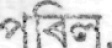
পৰিল,
